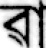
ৱা
